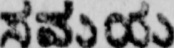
ಸಮಯ
